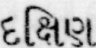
દક્ષિણ
